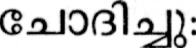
ചോദിച്ചു:
